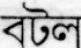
বটল
